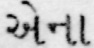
એના
